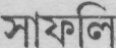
সাফলি
